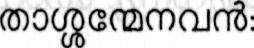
താശ്ശന്മേനവന്‍:
